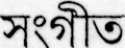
সংগীত
